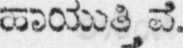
ಹಾಯುತ್ತಿವೆ.
